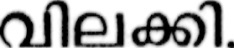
വിലക്കി.
